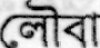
লৌবা
